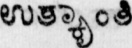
ಉತ್ಕ್ರಾಂತಿ
